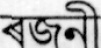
ৰজনী
